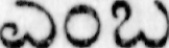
ಎಂಬ
